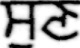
ਸੁਣ
